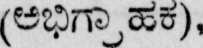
(ಅಭಿಗ್ರಾಹಕ),
